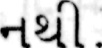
નથી.
